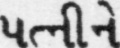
પત્નીને
